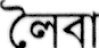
লৈবা
